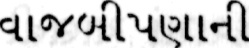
વાજબીપણાની
